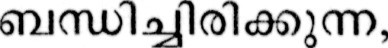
ബന്ധിച്ചിരിക്കുന്ന,
